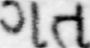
ગત
